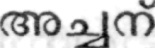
അച്ചന്
